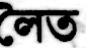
লৈত
